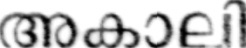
അകാലി
